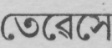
তেৱেসে
